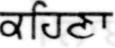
ਕਹਿਣਾ
